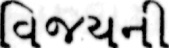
વિજયની
